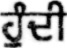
ਹੁੰਦੀ
